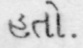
હતો.
